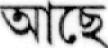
আছে
